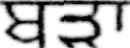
ਬੜਾ
